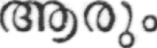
ആരും
